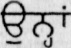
ਉਨ੍ਹਾਂ
